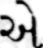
એ
